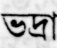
ভদ্রা
